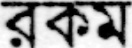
রকম
